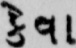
કેવા
